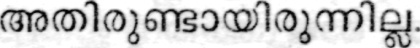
അതിരുണ്ടായിരുന്നില്ല.
